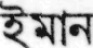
ইমান
